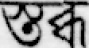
স্তব্ধ
